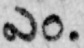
ಎಂ.
